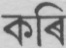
কৰি
